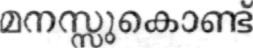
മനസ്സുകൊണ്ട്
